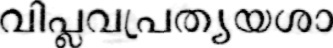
വിപ്ലവപ്രത്യയശാ
